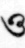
ও
